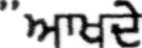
''ਆਖਦੇ
